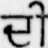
ਦੀ
